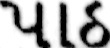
પાઠ
